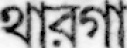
থারগা
